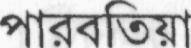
পারবতিয়া
